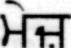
ਮੇਜ਼
